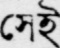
সেই
